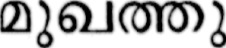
മുഖത്തു
